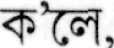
ক'লে,
